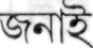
জনাই
